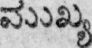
ಮುಖ್ಯ
